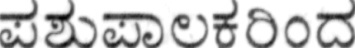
ಪಶುಪಾಲಕರಿಂದ
